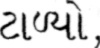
ટાળ્યો,
